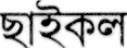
ছাইকল
